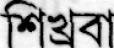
শিখ্রবা
